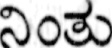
ನಿಂತು
